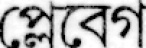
প্লেবেগ
